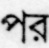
পর
